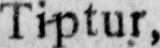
Tiptur,
